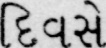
દિવસે
